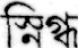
স্নিগ্ধ
